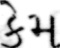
કેમ
